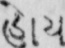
હોય
